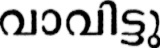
വാവിട്ടു
